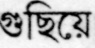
গুছিয়ে
